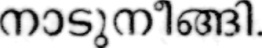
നാടുനീങ്ങി.
